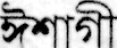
ঈশাগী
